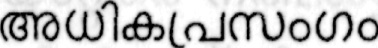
അധികപ്രസംഗം
